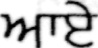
ਆਏ
